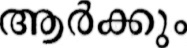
ആര്‍ക്കും
